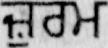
ਜ਼ੁਰਮ
